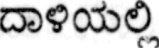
ದಾಳಿಯಲ್ಲಿ
